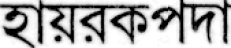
হায়রকপদা
